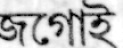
জগোই
